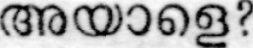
അയാളെ?
